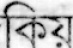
কিয়
